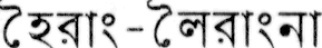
হৈরাং-লৈরাংনা
